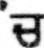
'ਚ
